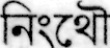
নিংথৌ
